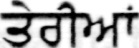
ਤੇਰੀਆਂ
